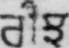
ਰੀਝ
